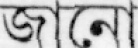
জানো
